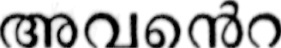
അവന്റെ
